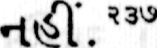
નહીં.૨૩૭
